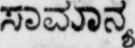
ಸಾಮಾನ್ಯ
